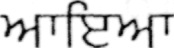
ਆਇਆ
